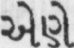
એણે
